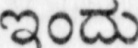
ಇಂದು
